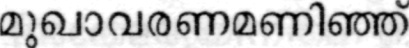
മുഖാവരണമണിഞ്ഞ്
